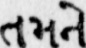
તમને
